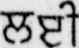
ਲਈ
